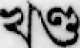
খণ্ড
